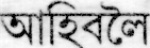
আহিবলৈ
